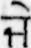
ਜੇ
